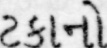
ટકાનો
